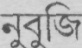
নুবুজি
